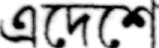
এদেশে
